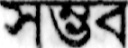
সম্ভব
